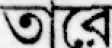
তারে
